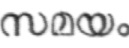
സമയം
